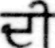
ਦੀ
